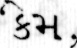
'કેમ,
